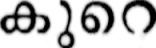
കുറെ
